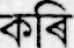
কৰি
